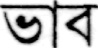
ভাব
